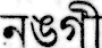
নঙগী
